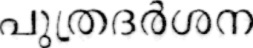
പുത്രദര്‍ശന
